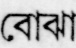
বোঝা
